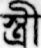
স্ত্রী
